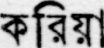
করিয়া
